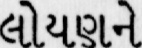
લોયણને
